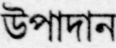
উপাদান
